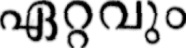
ഏറ്റവും
